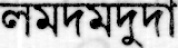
লমদমদুদা
